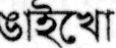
ঙাইখো
